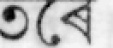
তৰে
